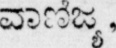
ವಾಣಿಜ್ಯ,
